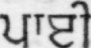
ਪਾਈ
